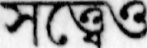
সত্ত্বেও
